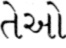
તેઓ
